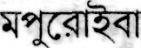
মপুরোইবা
